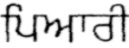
ਪਿਆਰੀ
